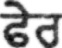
ਫੇਰ
